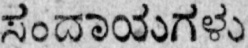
ಸಂದಾಯಗಳು
